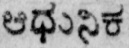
ಆಧುನಿಕ
